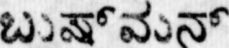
ಬುಷ್‌ಮನ್
